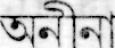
অনীনা
